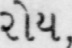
રોય,
